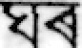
ঘৰ
